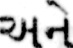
અને
